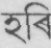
হৰি
